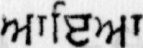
ਆਇਆ
